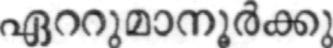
ഏററുമാനൂര്‍ക്കു
